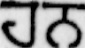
ਹਨ
